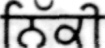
ਨਿੱਕੀ
